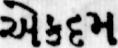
એકદમ
